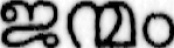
ജന്മം
